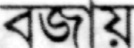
বজায়
